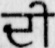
ਦੀ
